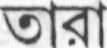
তারা
